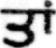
ਤਾਂ
